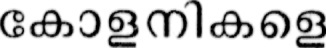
കോളനികളെ
